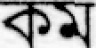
কম
